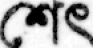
শেৎ
